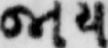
જાય
